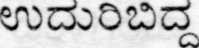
ಉದುರಿಬಿದ್ದ
